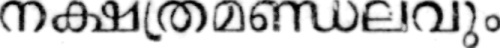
നക്ഷത്രമണ്ഡലവും
